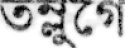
তম্লুগে
